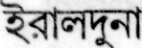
ইরালদুনা
